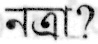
নত্রা?
